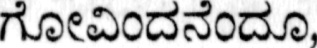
ಗೋವಿಂದನೆಂದೂ,
